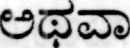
ಅಥವಾ
